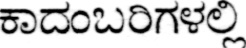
ಕಾದಂಬರಿಗಳಲ್ಲಿ
